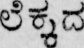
ಲೆಕ್ಕದ
